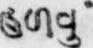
હળવું
